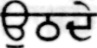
ਉਠਦੇ
